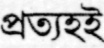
প্রত্যহই
